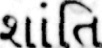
શાંતિ
